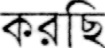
করেছি
